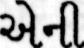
એની
